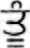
ਤੂੰ
